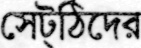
সেট্ঠিদের
